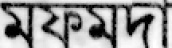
মফমদা
